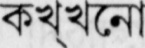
কখ্‌খনো
